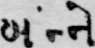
બન્ને
